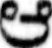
ಆ
